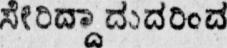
ಸೇರಿದ್ದಾದುದರಿಂದ
